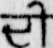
ਦੀ
